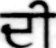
ਦੀ
